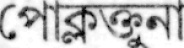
পোক্লক্তুনা
